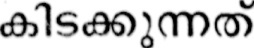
കിടക്കുന്നത്
